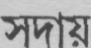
সদায়
